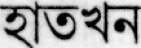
হাতখন
